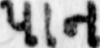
પાન
